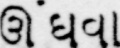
ઊંઘવા
